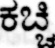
ಕಚ್ಚಿ
